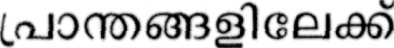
പ്രാന്തങ്ങളിലേക്ക്
